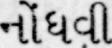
નોંધવી
